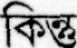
কিন্তু
